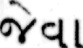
જેવા
